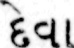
દેવા
